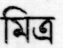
মিত্র
